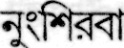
নুংশিরবা
